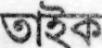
তাইক
